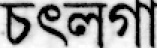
চৎলগা
